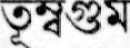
তূম্বগুম
